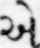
એ
